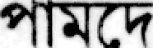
পামদে
